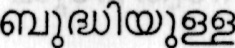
ബുദ്ധിയുള്ള
